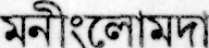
মনীংলোমদা
